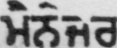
ਮੈਨੇਜਰ
